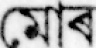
মোৰ
